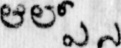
ಆಲ್ಫ್ಸ್
